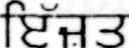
ਇੱਜ਼ਤ
